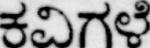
ಕವಿಗಳೆ
